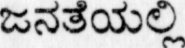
ಜನತೆಯಲ್ಲಿ
